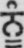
ਨੂੰ
